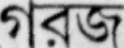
গরজ
